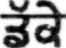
ਡੱਕੇ
